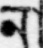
না
